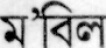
ম'বিল
